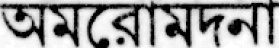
অমরোমদনা
